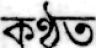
কণ্ঠত
